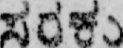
ಸರಕು
